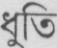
ধুতি
